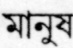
মানুষ
